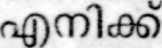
എനിക്ക്
